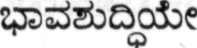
ಭಾವಶುದ್ಧಿಯೇ
